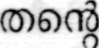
തന്റെ
